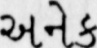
અનેક
